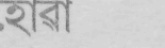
হোৱা
